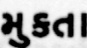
મુક્તા
